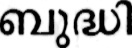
ബുദ്ധി
